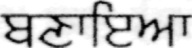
ਬਣਾਇਆ
